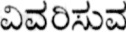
ವಿವರಿಸುವ
